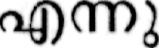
എന്നു
